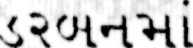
ડરબનમાં
